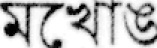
মখোঙ
